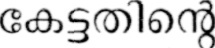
കേട്ടതിന്റെ
